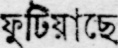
ফুটিয়াছে
